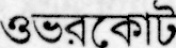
ওভরকোট
